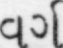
વર્ગ
